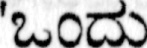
‘ಒಂದು
